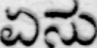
ಏನು
